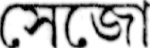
সেজো
